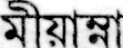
মীয়াম্না
